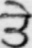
ਤੇ
